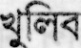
খুলিব
